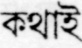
কথাই
